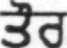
ਤੌਰ
